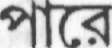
পারে
